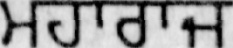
ਮਹਾਰਾਜ
